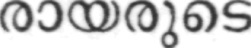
രായരുടെ
